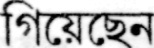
গিয়েছেন
